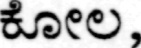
ಕೋಲ,
